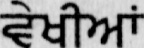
ਵੇਖੀਆਂ
